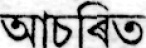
আচৰিত
